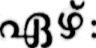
ഏഴ്:
